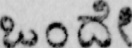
ಒಂದೇ
